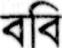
ববি
